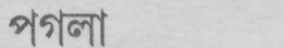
পগলা
